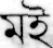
মই
